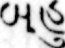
બહુ
